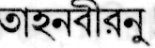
তাহনবীগনু
